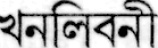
খনলিবনী
